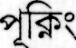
পূক্নিং
